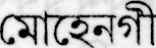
মোহেনগী
